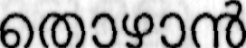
തൊഴാന്‍
